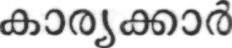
കാര്യക്കാര്‍
